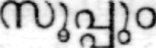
സൂപ്പും
